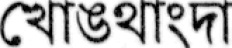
খোঙথাংদা
